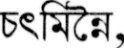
চৎমিন্নৈ,
